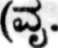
(ವೃ.
